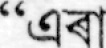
"এৰা
